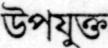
উপযুক্ত
